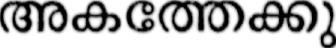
അകത്തേക്കു
